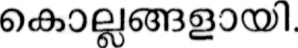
കൊല്ലങ്ങളായി.
